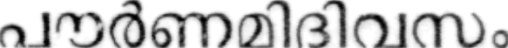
പൌര്‍ണമിദിവസം
